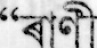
"ৰাণী
